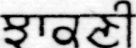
ਝਾਕਣੀ
